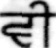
ਵੀ
